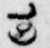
ತ
